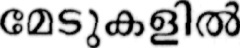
മേടുകളില്‍
